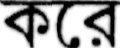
করে
